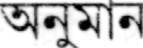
অনুমান
